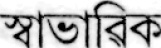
স্বাভাৱিক
